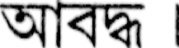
আবদ্ধ।
